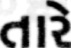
તારે
